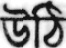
উঠি
